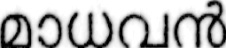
മാധവന്‍
